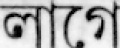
লাগে
